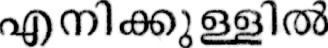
എനിക്കുള്ളില്‍
